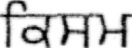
ਕਿਸਮ
